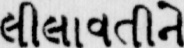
લીલાવતીને
